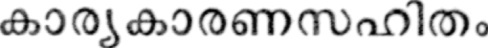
കാര്യകാരണസഹിതം
